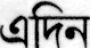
এদিন
